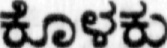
ಕೊಳಕು
